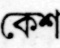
কেশ
